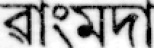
ৱামদা
